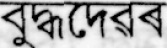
বুদ্ধদেৱৰ
